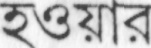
হওয়ার
